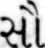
સૌ
